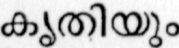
കൃതിയും
